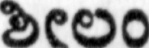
ಶೀಲಂ
